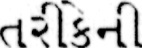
તરીકેની
